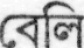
বেলি
